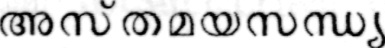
അസ്തമയസന്ധ്യ
